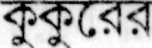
কুকুরের
